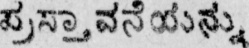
ಪ್ರಸ್ತಾವನೆಯನ್ನು
